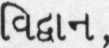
વિદ્વાન,
